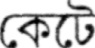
কেটে
